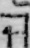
ਜੋ
